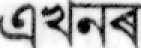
এখনৰ
